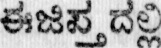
ಈಜಿಪ್ತದಲ್ಲಿ
